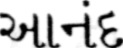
આનંદ
